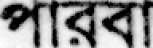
পারবা
